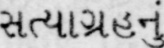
સત્યાગ્રહનું
